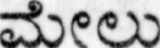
ಮೇಲು
